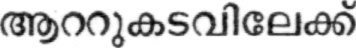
ആററുകടവിലേക്ക്
